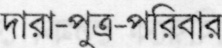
দারা-পুত্র-পরিবার
